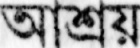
আশ্রয়
